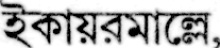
ইকায়রমাল্লে,
